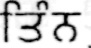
ਤਿੰਨ,
